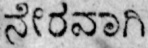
ನೇರವಾಗಿ
